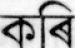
কৰি
